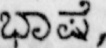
ಭಾಷೆ,
